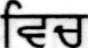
ਵਿਚ
